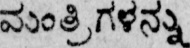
ಮಂತ್ರಿಗಳನ್ನು
